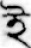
ই
